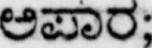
ಅಪಾರ;
